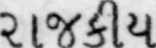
રાજકીય
